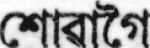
শোৱাগৈ
